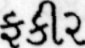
ફકીર
